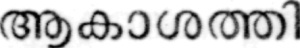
ആകാശത്തി
